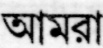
আমরা
